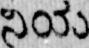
ನಿಯ
